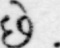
છે.
